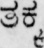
ತಕ್ಕ
